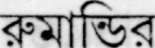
রুমান্ডির
